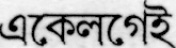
একেলগেই
